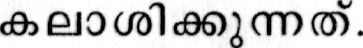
കലാശിക്കുന്നത്.
